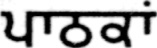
ਪਾਠਕਾਂ
